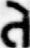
તે
